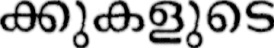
ക്കുകളുടെ
